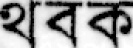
থবক
